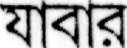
যাবার
